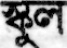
স্কুল
